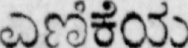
ಎಣಿಕೆಯ
